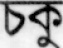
চকু
